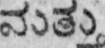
ಮತ್ತು
